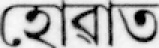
হোৱাত
